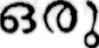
ഒരു
